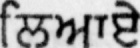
ਲਿਆਏ
